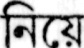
নিয়ে
